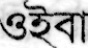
ওইবা
